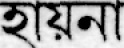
হায়না
